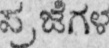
ಪ್ರಜೆಗಳ
